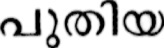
പുതിയ
